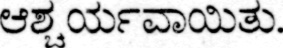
ಆಶ್ಚರ್ಯವಾಯಿತು.
